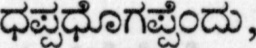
ಧಪ್ಪಧೊಗಪ್ಪೆಂದು,
